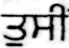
ਤੁਸੀਂ
